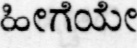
ಹೀಗೆಯೇ
